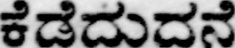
ಕೆಡೆದುದನೆ
